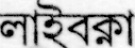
লাইবক্না
